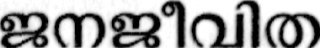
ജനജീവിത
